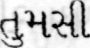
તુમસી
